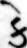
કે
